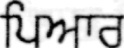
ਪਿਆਰ
